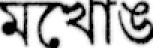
মখোঙ
